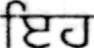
ਇਹ
